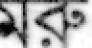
মরু
